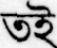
তই
